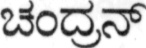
ಚಂದ್ರನ್
